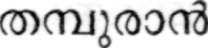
തമ്പുരാന്‍
